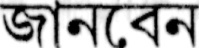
জানবেন
